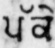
ਪੱਕੇ
